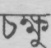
চক্ষু
